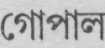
গোপাল
